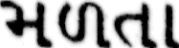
મળતા
